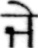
ਜੇ
